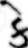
કે
